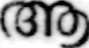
ആ
